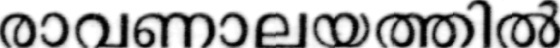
രാവണാലയത്തില്‍
